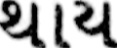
થાય
